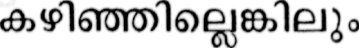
കഴിഞ്ഞില്ലെങ്കിലും
